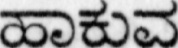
ಹಾಕುವ
